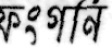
ফংগনি
